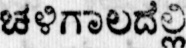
ಚಳಿಗಾಲದಲ್ಲಿ
